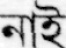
নাই
